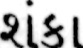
શંકા
